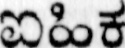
ಐಹಿಕ
